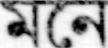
মনে
